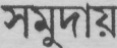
সমুদায়
